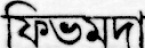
ফিভমদা
